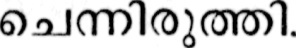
ചെന്നിരുത്തി.
